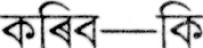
কৰিব-কি
